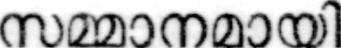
സമ്മാനമായി
